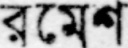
রমেশ
